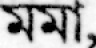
মমা,
